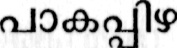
പാകപ്പിഴ
